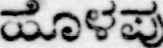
ಹೊಳಪು
